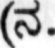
(ನ.
